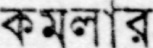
কমলার
